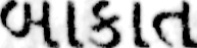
બાકાત
